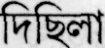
দিছিলা
